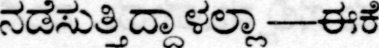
ನಡೆಸುತ್ತಿದ್ದಾಳಲ್ಲಾ-ಈಕೆ
